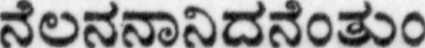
ನೆಲನನಾನಿದನೆಂತುಂ
